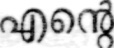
എന്റെ
